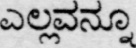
ಎಲ್ಲವನ್ನೂ
